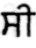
ਸੀ
